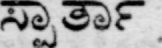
ಸ್ಪಾರ್ತಾ
